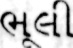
ભૂલી
